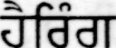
ਹੈਰਿੰਗ
